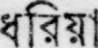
ধরিয়া
